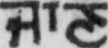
ਜਾਣ
